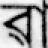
ৱা
